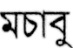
মচাবু
